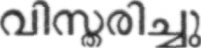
വിസ്തരിച്ചു
